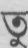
তু
